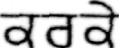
ਕਰਕੇ
